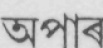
অপাৰ
